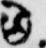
છે.
